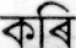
কৰি
